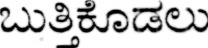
ಬುತ್ತಿಕೊಡಲು
